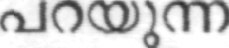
പറയുന്ന
